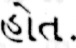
હોત.
